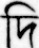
দি
